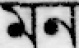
মন
